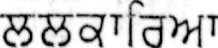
ਲਲਕਾਰਿਆ
